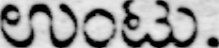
ಉಂಟು.
